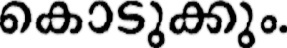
കൊടുക്കും.
